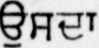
ਉਸਦਾ
